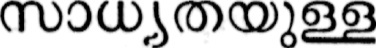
സാധ്യതയുള്ള
